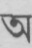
অ
